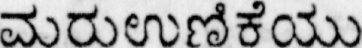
ಮರುಉಣಿಕೆಯು
